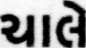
ચાલે
